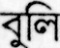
বুলি
